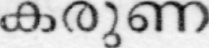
കരുണ
